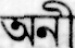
অনী
